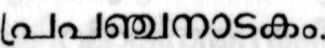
പ്രപഞ്ചനാടകം.
